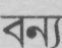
বন্য
